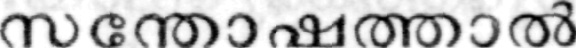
സന്തോഷത്താല്‍
